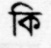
কি
